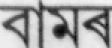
বামৰ
